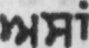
ਅਸਾਂ
